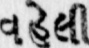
વહેલી
